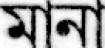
মানা
